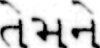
તેમને
